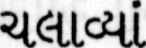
ચલાવ્યાં
